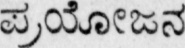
ಪ್ರಯೋಜನ
